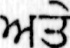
ਅਤੇ
